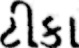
ટીકા
